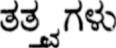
ತತ್ತ್ವಗಳು
